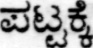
ಪಟ್ಟಕ್ಕೆ
